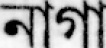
নাগা
